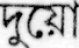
দুয়ো
